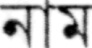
নাম
